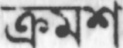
ক্রমশ
